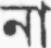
না
